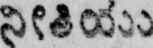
ನೀತಿಯು
